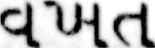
વખત
